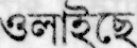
ওলাইছে
